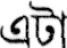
এটা
